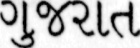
ગુજરાત
